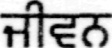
ਜੀਵਨ
